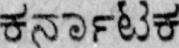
ಕರ್ನಾಟಕ
